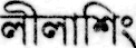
লীলাশিং
